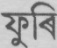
ফুৰি
